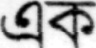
এক
